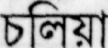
চলিয়া
